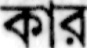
কার
